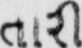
તારી
